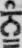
ਨੂੰ
